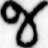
જ
